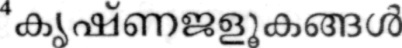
4കൃഷ്ണജളൂകങ്ങള്‍
